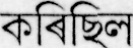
কৰিছিল
